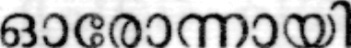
ഓരോന്നായി
